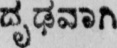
ದೃಢವಾಗಿ
